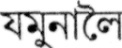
যমুনালৈ
